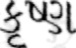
કૃષ્ણ
